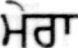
ਮੇਰਾ
